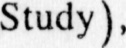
Study),
